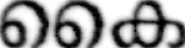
കൈ
